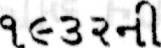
૧૯૩૨ની
